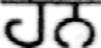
ਹਨ
